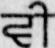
ਵੀ
